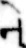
ને
